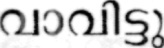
വാവിട്ടു
